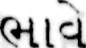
ભાવે
